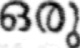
ഒരു
